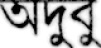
অদুবু
